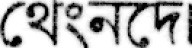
থেংনদে।
